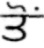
ਤੋਂ
